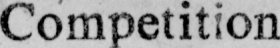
Competition
